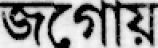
জগোয়
